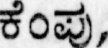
ಕೆಂಪು,
